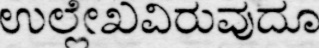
ಉಲ್ಲೇಖವಿರುವುದೂ
